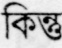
কিন্তু
